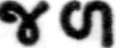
જળ
